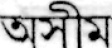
অসীম
